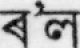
ৰ'ল
